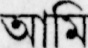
আমি
